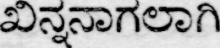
ಖಿನ್ನನಾಗಲಾಗಿ
